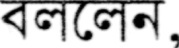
বললেন,
